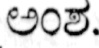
ಅಂಶ.
